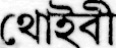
থোইবী
